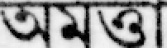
অমত্তা
